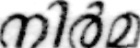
നിര്‍മ
